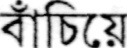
বাঁচিয়ে
